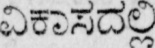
ವಿಕಾಸದಲ್ಲಿ
